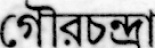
গৌরচন্দ্রা
